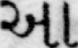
આ
